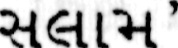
સલામ'
